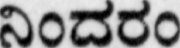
ನಿಂದರಂ
